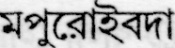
মপুরোইবদা
